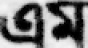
এম
